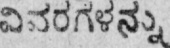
ವಿವರಗಳನ್ನು
